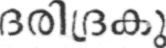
ദരിദ്രകു
